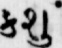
કશું
